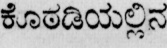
ಕೊಠಡಿಯಲ್ಲಿನ
